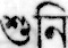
শুনি
